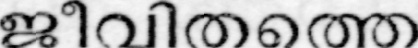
ജീവിതത്തെ
